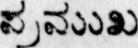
ಪ್ರಮುಖ
